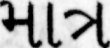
માત્ર
